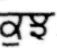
ਕੁਝ
